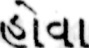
હોવા
